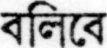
বলিবে
